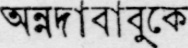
অন্নদাবাবুকে
